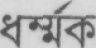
ধৰ্ম্মক
